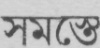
সমস্তে
